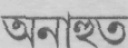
অনাহুত
